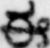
ಈ
